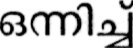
ഒന്നിച്ച്
